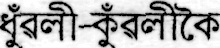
ধুঁৱলী-কুঁৱলীকৈ
